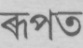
ৰূপত
